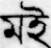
মই
